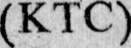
(KTC)
